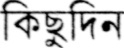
কিছুদিন
